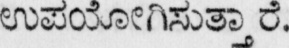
ಉಪಯೋಗಿಸುತ್ತಾರೆ.
